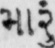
મારું
